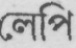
লেপি
